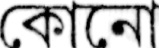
কোনো
